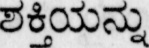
ಶಕ್ತಿಯನ್ನು
